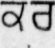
ਕਰ
